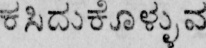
ಕಸಿದುಕೊಳ್ಳುವ
